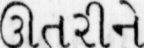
ઊતરીને
